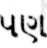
પણ
